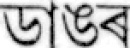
ডাঙৰ
